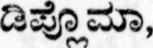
ಡಿಪ್ಲೊಮಾ,
